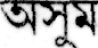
অসুম
